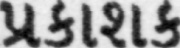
પ્રકાશક
